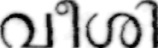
വീശി
